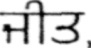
ਜੀਤ,
